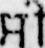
ਸੀ
